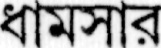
ধামসার
